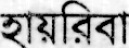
হায়রিবা
